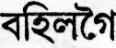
বহিলগৈ
